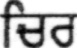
ਚਿਰ
